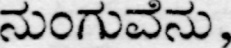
ನುಂಗುವೆನು,
